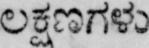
ಲಕ್ಷಣಗಳು
